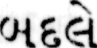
બદલે
